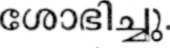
ശോഭിച്ചു.
